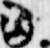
છે.
